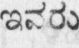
ಇವರು
